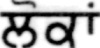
ਲੋਕਾਂ
